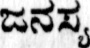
ಜನಸ್ಯ
